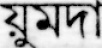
য়ুমদা
